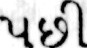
પછી
